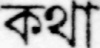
কথা
